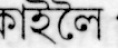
কাইলৈ
